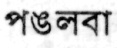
পঙলবা
